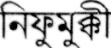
নিফুমুক্কী
